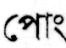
পোং
